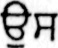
ਉਸ
